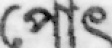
পোৎ
